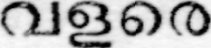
വളരെ
